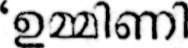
‘ഉമ്മിണി
